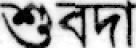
শুবদা
